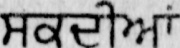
ਸਕਦੀਆਂ
